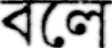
বলে
